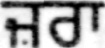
ਜ਼ਰਾ
